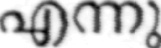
എന്നു
